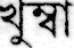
খুম্বা
